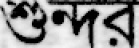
শুন্দর
